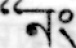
“নং
